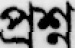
প্রশ্ন
